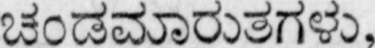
ಚಂಡಮಾರುತಗಳು,
